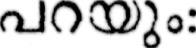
പറയും:
